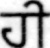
ਹੀ
